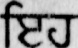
ਇਹ
